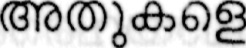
അതുകളെ
